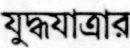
যুদ্ধযাত্রার
